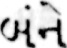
બંને
